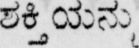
ಶಕ್ತಿಯನ್ನು
